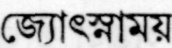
জ্যোত্স্নাময়
